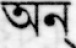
অন্
